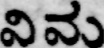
ವಿಮ
